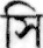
সি
